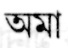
অমা
